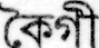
কৈগী
